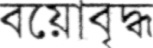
বয়োবৃদ্ধ
